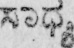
ಸಾಧ್ಯ
